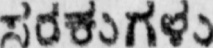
ಸರಕುಗಳು
